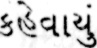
કહેવાયું
